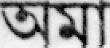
অমা
